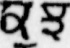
ਕੁਝ
